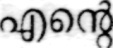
എന്റെ
